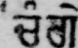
'ਚੰਗੇ
